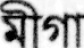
মীগা
